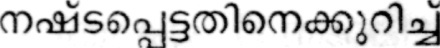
നഷ്ടപ്പെട്ടതിനെക്കുറിച്ച്
